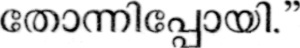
തോന്നിപ്പോയി.”
